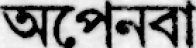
অপেনবা
